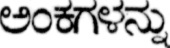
ಅಂಕಗಳನ್ನು
